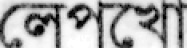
লেপখো
